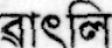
ৱাৎলি
